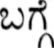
ಬಗ್ಗೆ
